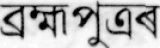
ব্রহ্মপুত্রৰ
